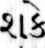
શકે
